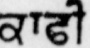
ਕਾਫੀ
